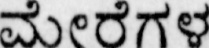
ಮೇರೆಗಳ
